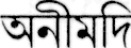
অনীমদি
